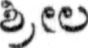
ಶ್ರೀಲ
